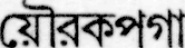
য়ৌরকপগা
